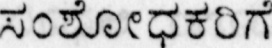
ಸಂಶೋಧಕರಿಗೆ
